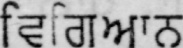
ਵਿਗਿਆਨ
